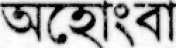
অহোংবা
